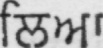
ਲਿਆ
